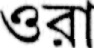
ওরা
